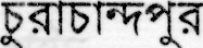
চুরাচান্দপুর
